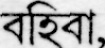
বহিবা,
